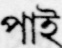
পাই
